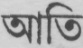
আতি
